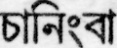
চানিংবা
